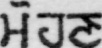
ਮੋਹਣ
